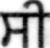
ਸੀ
